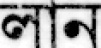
লান
